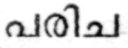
പരിച
